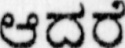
ಆದರೆ
